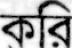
করি
